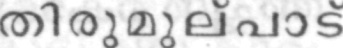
തിരുമുല്പാട്
